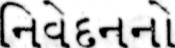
નિવેદનનો
